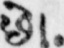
છો.
